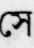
সে
